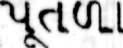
પૂતળા
